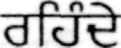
ਰਹਿੰਦੇ
